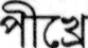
পীখ্রে
